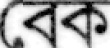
বেক
